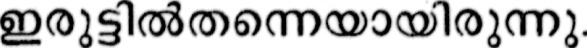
ഇരുട്ടില്‍തന്നെയായിരുന്നു.
